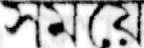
সময়ে
